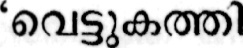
'വെട്ടുകത്തി
